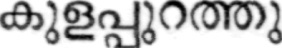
കുളപ്പുറത്തു
